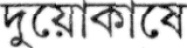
দুয়োকাষে
